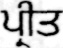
ਪ੍ਰੀਤ
